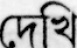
দেখি
